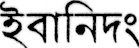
ইবানিদং
